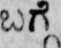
ಬಗ್ಗೆ
